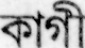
কাগী
